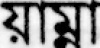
য়াম্না
